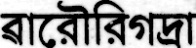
ৱারৌরিগদ্রা
